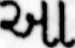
આ
